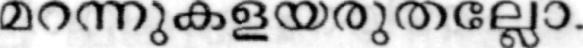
മറന്നുകളയരുതല്ലോ.
